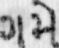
ગમે
